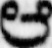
ಆ
